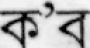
ক'ব
